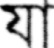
যা
